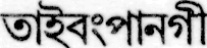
তাইবংপানগী
